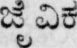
ಜೈವಿಕ
